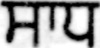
ਸਾਧ
